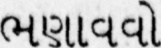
ભણાવવો
